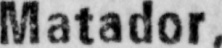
Matador,
